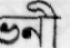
ভনী
